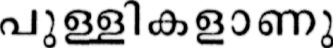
പുള്ളികളാണു
